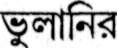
ভুলানির
